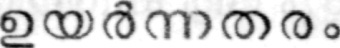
ഉയര്‍ന്നതരം
